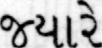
જ્યારે
